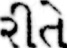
રીતે
